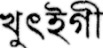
খুৎইগী
